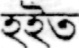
হইত
